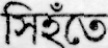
সিহঁতে
